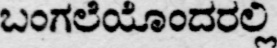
ಬಂಗಲೆಯೊಂದರಲ್ಲಿ
